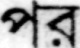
পর
